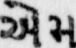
એમ
